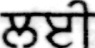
ਲਈ
